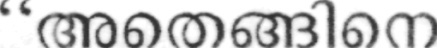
"അതെങ്ങിനെ
